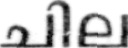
ചില
